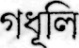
গধূলি
